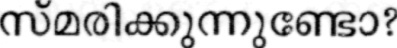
സ്മരിക്കുന്നുണ്ടോ?
